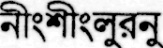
নীংশীংলুরনু
